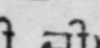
ਦੀ
